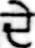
ਦੇ
